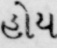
હોય
